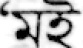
'মই
